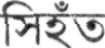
সিহঁত
